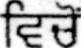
ਵਿਚੋਂ
